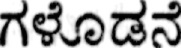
ಗಳೊಡನೆ
